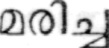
മരിച്ച
